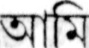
আমি
